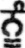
ਨੂੰ
